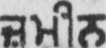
ਜ਼ਮੀਨ
